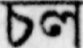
চল
